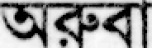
অরুবা
